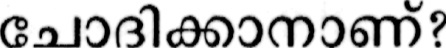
ചോദിക്കാനാണ്?
